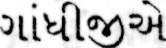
ગાંધીજીએ
